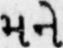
મને
